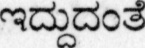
ಇದ್ದುದಂತೆ
